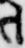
તે
